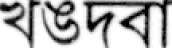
খঙদবা
